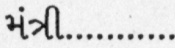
મંત્રી...........
